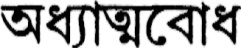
অধ্যাত্মবোধ
